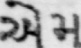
એમ
